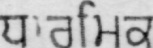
ਧਾਰਮਿਕ
